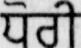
ਧੋਰੀ
